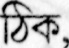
ঠিক,
